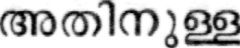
അതിനുള്ള
